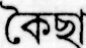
কৈছা
